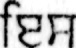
ਇਸ
